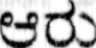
ಆರು
